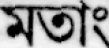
মতাং
